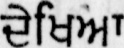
ਦੇਖਿਆ
